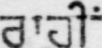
ਰਾਹੀਂ
